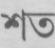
শত
